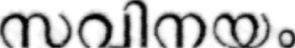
സവിനയം
